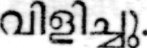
വിളിച്ചു.
